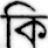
কি
